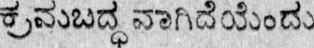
ಕ್ರಮಚದ್ಧವಾಗಿದೆಯೆಂದು
